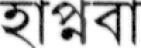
হাপ্নবা
